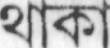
থাকা
